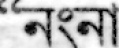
“নংনা
